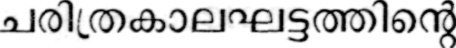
ചരിത്രകാലഘട്ടത്തിന്റെ
